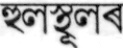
হুলস্হূলৰ
